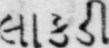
લાકડી
